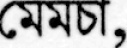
মেমচা,
